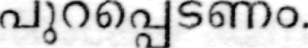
പുറപ്പെടണം.
